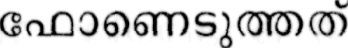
ഫോണെടുത്തത്
